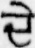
ਦੇ
